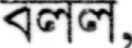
বলল,
